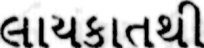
લાયકાતથી
